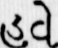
હવે
